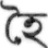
হৈ
